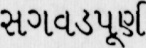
સગવડપૂર્ણ
